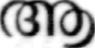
ആ
